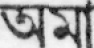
অমা
